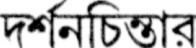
দর্শনচিন্তার
